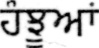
ਹੰਝੂਆਂ
